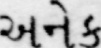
અનેક
